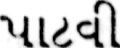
પાટવી
